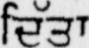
ਦਿੱਤਾ
